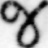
જ
